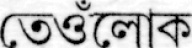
তেওঁলোক
